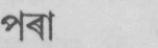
পৰা
